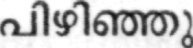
പിഴിഞ്ഞു
